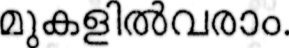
മുകളില്‍വരാം.
